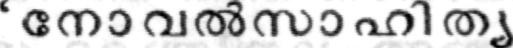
'നോവല്‍സാഹിത്യ
